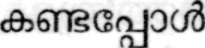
കണ്ടപ്പോള്‍
